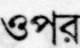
ওপর
